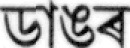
ডাঙৰ
